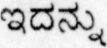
ಇದನ್ನು
